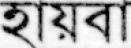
হায়বা
